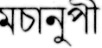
মচানুপী
